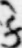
કે
